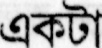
একটা
